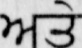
ਅਤੇ
